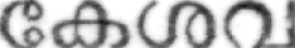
കേശവ
